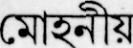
মোহনীয়
